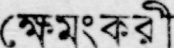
ক্ষেমংকরী
